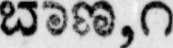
ಬಾಣ,೧
